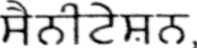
ਸੈਨੀਟੇਸ਼ਨ,
